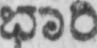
ಭಾರಿ
